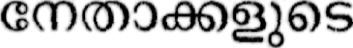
നേതാക്കളുടെ
